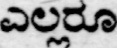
ಎಲ್ಲರೂ
